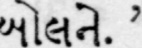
ખોલને.'
